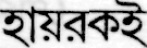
হায়রকই
